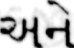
અને
